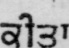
ਕੀਤਾ
